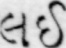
લઈ
